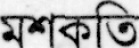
মশকতি
